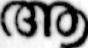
ആ
